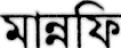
মান্নফি
